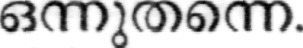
ഒന്നുതന്നെ.
